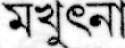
মখুৎনা
